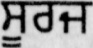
ਸੂਰਜ
